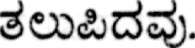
ತಲುಪಿದವು.
